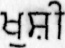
ਖੁਸ਼ੀ
